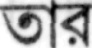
তার
